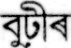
বুঢীৰ
